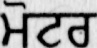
ਮੋਟਰ
